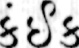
કંઈક
